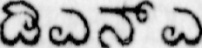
ಡಿಎನ್ಎ
